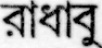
রাধাবু
